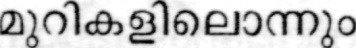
മുറികളിലൊന്നും
